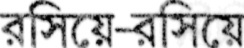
রসিয়ে-রসিয়ে
